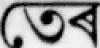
তেৰ
